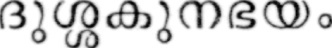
ദുശ്ശകുനഭയം
